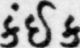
કંઈક
